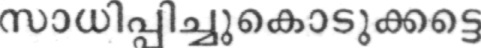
സാധിപ്പിച്ചുകൊടുക്കട്ടെ
